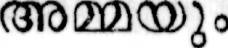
അമ്മയും
